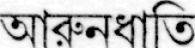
আরুনধাতি
